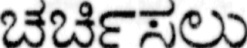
ಚರ್ಚಿಸಲು
